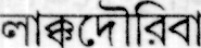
লাক্কদৌরিবা
